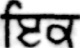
ਇਕ
